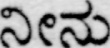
ನೀನು
